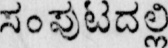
ಸಂಪುಟದಲ್ಲಿ
